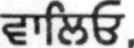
ਵਾਲਿਓ,
